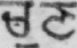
ਚੁਣ
